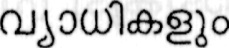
വ്യാധികളും
